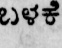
ಬಳಕೆ
